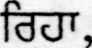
ਰਿਹਾ,
